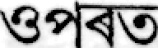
ওপৰত
